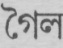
গৈল
